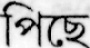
পিছে
